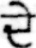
ਦੇ
